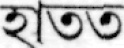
হাতত
